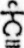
ਨੂੰ
